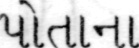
પોતાના
